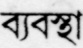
ব্যবস্থা
